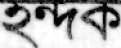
হন্দক
